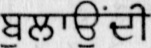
ਬੁਲਾਉਂਦੀ
